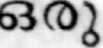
ഒരു
